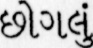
છોગલું
